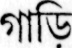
গাড়ি
